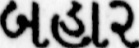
બહાર
